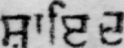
ਸ਼ਾਇਦ
